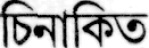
চিনাকিত
